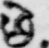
છે.
